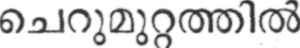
ചെറുമുറ്റത്തില്‍
